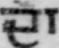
ਦਾ
